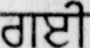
ਗਈ
